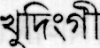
খুদিংগী
